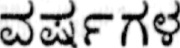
ವರ್ಷಗಳ
